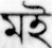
মই
